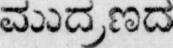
ಮುದ್ರಣದ
